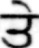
ਤੇ
